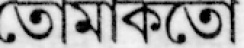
তোমাকতো
